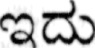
ಇದು
